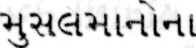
મુસલમાનોના
